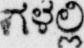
ಗಳಲ್ಲಿ
